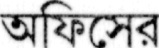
অফিসের
